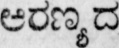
ಅರಣ್ಯದ
